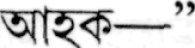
আহক-"
